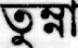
তুম্না
